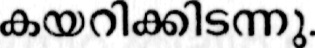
കയറിക്കിടന്നു.
